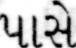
પાસે
